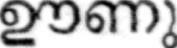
ഊണു
